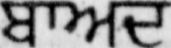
ਬਾਅਦ
